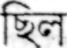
ছিল
